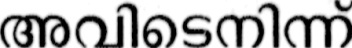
അവിടെനിന്ന്
